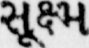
સૂક્ષ્મ
